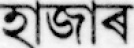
হাজাৰ
